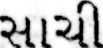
સાચી
